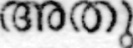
അതു
